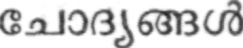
ചോദ്യങ്ങള്‍
